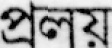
প্রলয়
